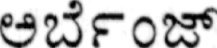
ಅರ್ಬೆಂಜ್
